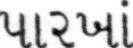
પારખાં
